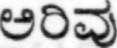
ಅರಿವು
